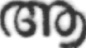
ആ
